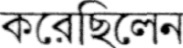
করেছিলেন
